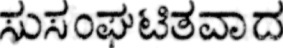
ಸುಸಂಘಟಿತವಾದ
